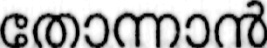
തോന്നാന്‍
